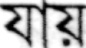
যায়
